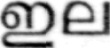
ഇല
